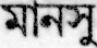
মানসু
